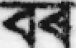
বৰ
